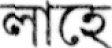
লাহে
